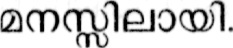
മനസ്സിലായി.
